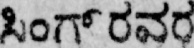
ಸಿಂಗ್ರವರ
